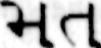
મત
